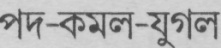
পদ-কমল-যুগল
